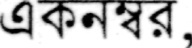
একনম্বর,
